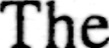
The
